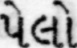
પેલો
